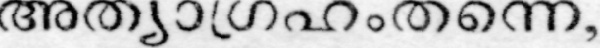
അത്യാഗ്രഹംതന്നെ,
